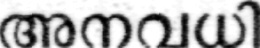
അനവധി
